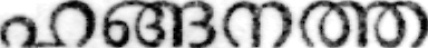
ഹങ്ങനത്ത
